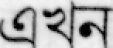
এখন
